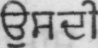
ਉਸਦੀ
